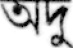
অদু
